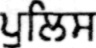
ਪੁਲਿਸ
